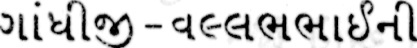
ગાંધીજી-વલ્લભભાઈની
